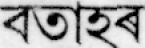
বতাহৰ
